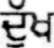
ਦੁੱਖ
